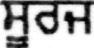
ਸੂਰਜ
